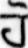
ਹੋ
